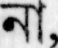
না,
